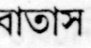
বাতাস
